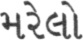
મરેલો
